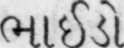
ભાઈડો
